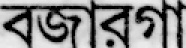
বজারগা
